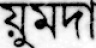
য়ুমদা
